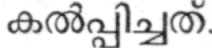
കല്‍പ്പിച്ചത്.
